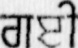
ਗਈ
